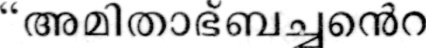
“അമിതാഭ്ബച്ചൻെറ
